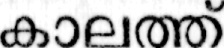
കാലത്ത്
